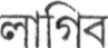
লাগিব
